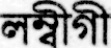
লম্বীগী
